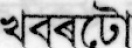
খবৰটো
